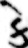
કે
